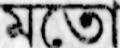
মতো
